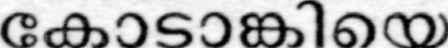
കോടാങ്കിയെ
